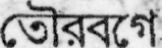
তৌরবগে
